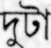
দুটা
